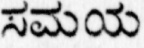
ಸಮಯ
